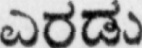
ಎರಡು
